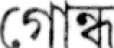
গোন্ধ
